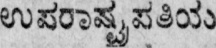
ಉಪರಾಷ್ಟ್ರಪತಿಯ
